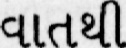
વાતથી
